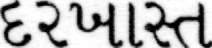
દરખાસ્ત
